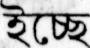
ইচ্ছে
